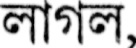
লাগল,
